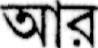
আর
